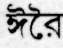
ঈরৈ
